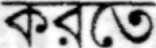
করতে
